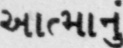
આત્માનું
